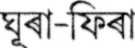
ঘূৰা-ফিৰা
